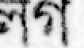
লগ
